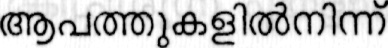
ആപത്തുകളില്‍നിന്ന്
